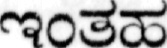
ಇಂತಹ
